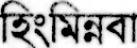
হিংমিন্নবা
